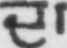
ਦਾ
